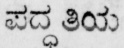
ಪದ್ಧತಿಯ
